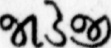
જાડેજી
